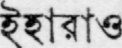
ইহারাও
